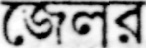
জেলর
